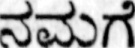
ನಮಗೆ
